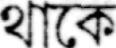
থাকে
